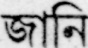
জানি
